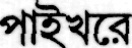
পাইখরে
